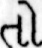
તો
